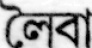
লৈবা
